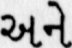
અને
